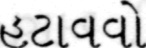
હટાવવો
